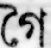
গৈ
